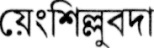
য়েংশিল্লুবদা
